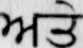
ਅਤੇ
